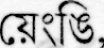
য়েংঙি,
